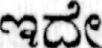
ಇದೇ
